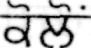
ਕੋਲੋਂ
